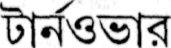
টার্নওভার
